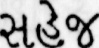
સહેજ
